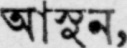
আসুন,
